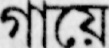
গায়ে
